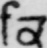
ਕਿ
